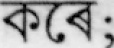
কৰে;
